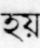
হয়
